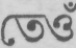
তেওঁ
